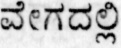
ವೇಗದಲ್ಲಿ
